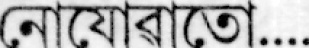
নোযোৱাতো....
